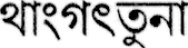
থাংগৎতুনা
